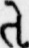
તે
